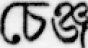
চেঞ্জ
